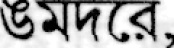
ঙমদরে,
